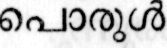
പൊരുള്‍
